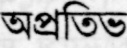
অপ্রতিভ
